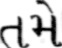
તમે
